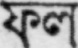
ফল
